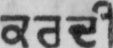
ਕਰਦੀ
